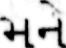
મને
